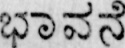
ಭಾವನೆ
